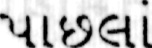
પાછલાં
